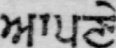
ਆਪਣੇ
